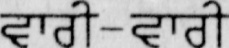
ਵਾਰੀ-ਵਾਰੀ
